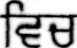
ਵਿਚ
